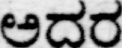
ಅದರ
